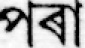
পৰা
